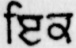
ਇਕ
